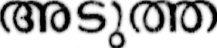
അടുത്ത
